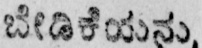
ಬೇಡಿಕೆಯನ್ನು
